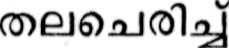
തലചെരിച്ച്
